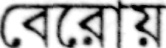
বেরোয়
